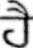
ਹੈ
